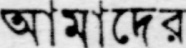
আমাদের
